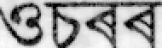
ওচৰৰ
